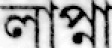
লাপ্না
